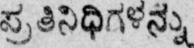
ಪ್ರತಿನಿಧಿಗಳನ್ನು
